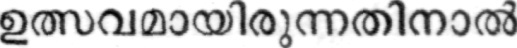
ഉത്സവമായിരുന്നതിനാല്‍
